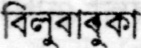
বিলুবাবুকা
